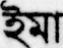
ইমা
